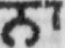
ਨਾ
